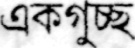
একগুচ্ছ
